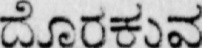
ದೊರಕುವ
